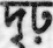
দৃঢ়
